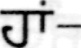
ਹਾਂ-
